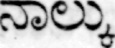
ನಾಲ್ಕು
